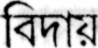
বিদায়
